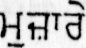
ਮੁਜ਼ਾਰੇ
